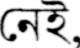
নেই,
